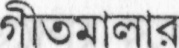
গীতমালার
